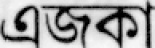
এজকা
